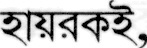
হায়রকই,
